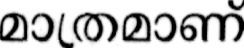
മാത്രമാണ്
